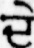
ਦੇ
